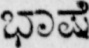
ಭಾಷೆ
